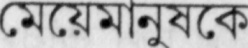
মেয়েমানুষকে
